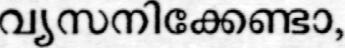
വ്യസനിക്കേണ്ടാ,
